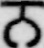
ਨ
